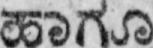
ಹಾಗೂ
